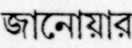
জানোয়ার
